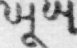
ખૂબ
